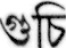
গুচি
